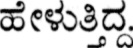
ಹೇಳುತ್ತಿದ್ದ.
